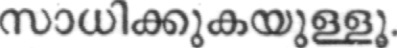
സാധിക്കുകയുള്ളൂ.
